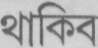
থাকিব
